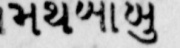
પ્રમથબાબુ
